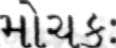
મોચકઃ
